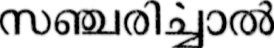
സഞ്ചരിച്ചാല്‍
